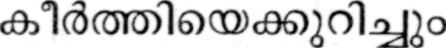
കീര്‍ത്തിയെക്കുറിച്ചും
